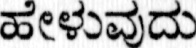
ಹೇಳುವುದು
